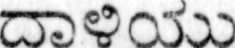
ದಾಳಿಯು
